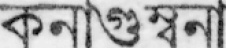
কনাগুম্বনা
